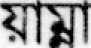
য়াম্না
